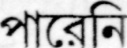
পারেনি
